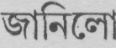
জানিলো
